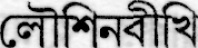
লৌশিনবীখি
